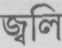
জ্বলি
